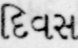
દિવસ
